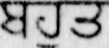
ਬਹੁਤ
